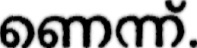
ണെന്ന്.
